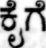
ಕೈಗೆ
